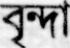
বৃন্দা
